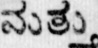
ಮತ್ತು
